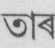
তাৰ
